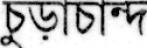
চুড়চান্দ
